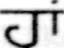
ਹਾਂ
